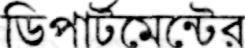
ডিপার্টমেন্টের
